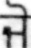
ਜੋ
